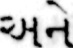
અને
